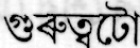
গুৰুত্বটো
